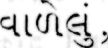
વાળેલું,
